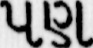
પણ
